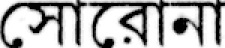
সোরোনা
